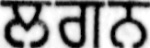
ਲਗਨ
